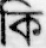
কি
